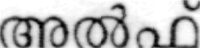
അല്‍ഫ്
